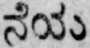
ನೆಯ
